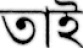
তাই
